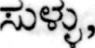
ಸುಳ್ಳು,
